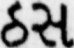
ઠસ
